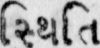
સ્થિતિ
